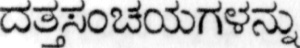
ದತ್ತಸಂಚಯಗಳನ್ನು
